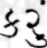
કરું
